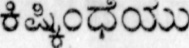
ಕಿಷ್ಕಿಂಧೆಯು
